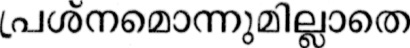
പ്രശ്നമൊന്നുമില്ലാതെ
